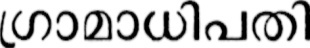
ഗ്രാമാധിപതി
